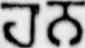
ਹਨ
